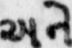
અને
